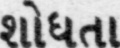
શોધતા
